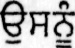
ਉਸਨੂੰ
